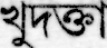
খুদ্ক্তা
